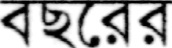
বছরের
